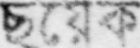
ছয়েক
